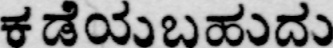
ಕಡೆಯಬಹುದು
